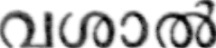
വശാല്‍
